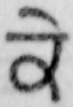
ਕੇ
